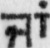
ਜਾਂ
